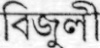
বিজুলী
